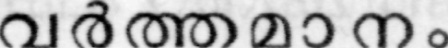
വര്‍ത്തമാനം
